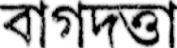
বাগদত্তা
